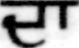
ਦਾ
